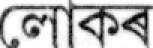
লোকৰ
